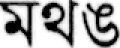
মথঙ
